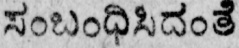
ಸಂಬಂಧಿಸಿದಂತೆ
